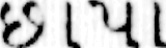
છાપા
